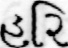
હરિ
